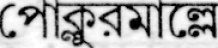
পোক্লুরমাল্লে
